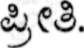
ಪ್ರೀತಿ.
